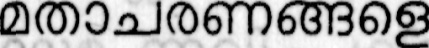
മതാചരണങ്ങളെ
